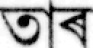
তাৰ
